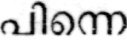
പിന്നെ
